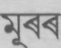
মূৰৰ
